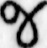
જ
